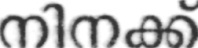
നിനക്ക്
